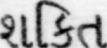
શક્તિ
